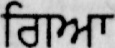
ਗਿਆ
